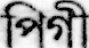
পিগী
